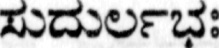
ಸುದುರ್ಲಭಃ
